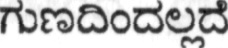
ಗುಣದಿಂದಲ್ಲದೆ
